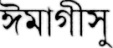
ঈমাগীসু
